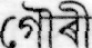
গৌৰী
